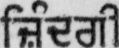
ਜ਼ਿੰਦਗੀ
